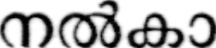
നല്‍കാ
